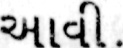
આવી.
